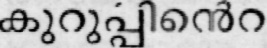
കുറുപ്പിന്റെ
